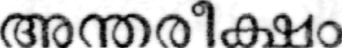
അന്തരീക്ഷം
